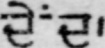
ਦੇਂਦਾ
